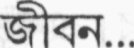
জীবন...
